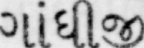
ગાંધીજી
